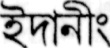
ইদানীং
